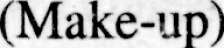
(Make-up)
